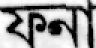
ফনা
